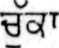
ਚੁੱਕਾ
